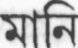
মানি
